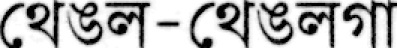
থেঙল-থেঙলগা
